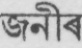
জনীৰ
